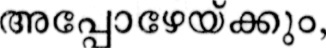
അപ്പോഴേയ്ക്കും,
